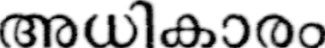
അധികാരം
